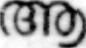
ആ
